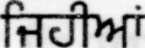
ਜਿਹੀਆਂ
